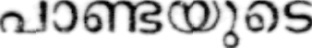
പാണ്ടയുടെ
